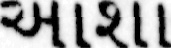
આશા
